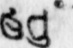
હતું
